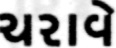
ચરાવે
